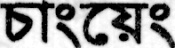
চাংয়েং
